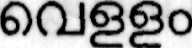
വെള്ളം
